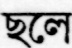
ছলে
